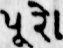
પૂરો
